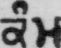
ਕੰਮ
